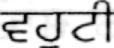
ਵਹੁਟੀ
